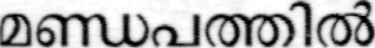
മണ്ഡപത്തില്‍
